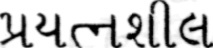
પ્રયત્નશીલ
